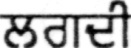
ਲਗਦੀ
